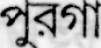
পুরগা
